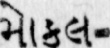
મોકલ-
